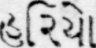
હરિયો
